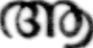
ആ
